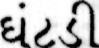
ઘંટડી
